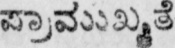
ಪ್ರಾಮುಖ್ಯತೆ
